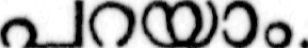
പറയാം.
